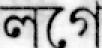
লগে
